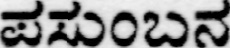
ಪಸುಂಬನ
